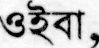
ওইবা,
